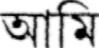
আমি
